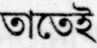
তাতেই
